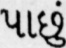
પાછું
